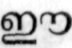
ഈ
